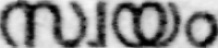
സ്വയം
